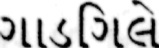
ગાડગિલે
